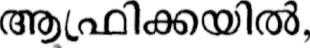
ആഫ്രിക്കയില്‍,
